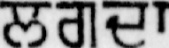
ਲਗਦਾ
